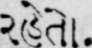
રહેતો.
